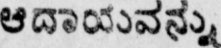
ಆದಾಯವನ್ನು
